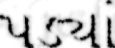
પડ્યાં
